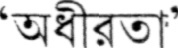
‘অধীরতা’
